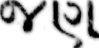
જણ
